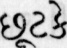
છૂટકે
